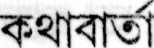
কথাবার্তা
